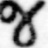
જ
